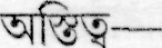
অস্তিত্ব-
